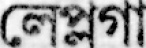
লেপ্লগা
